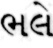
ભલે
